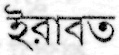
ইরাবত
